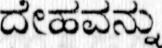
ದೇಹವನ್ನು
